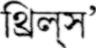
থ্রিল্‌স'
